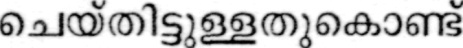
ചെയ്തിട്ടുള്ളതുകൊണ്ട്
